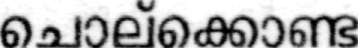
ചൊല്ക്കൊണ്ട
